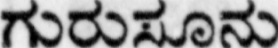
ಗುರುಸೂನು
